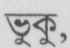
ভুকু,
